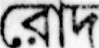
রোদ
